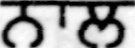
ਨਾਲ
